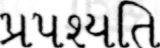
પ્રપશ્યતિ
